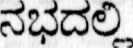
ನಭದಲ್ಲಿ
